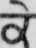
ਕੇ
